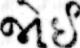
જોઈ
